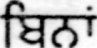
ਬਿਨਾਂ
